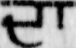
ਦਾ
